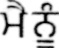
ਮੈਨੂੰ
